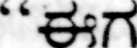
"ಈಗ
